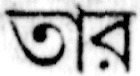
তার
